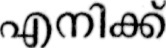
എനിക്ക്
